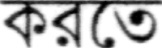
করতে
